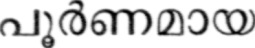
പൂര്‍ണമായ
